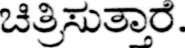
ಚಿತ್ರಿಸುತ್ತಾರೆ.
